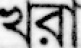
খরা
